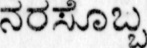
ನರಸೊಬ್ಬ
